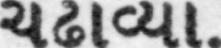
ચઢાવ્યા.
